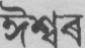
ঈশ্বৰ
